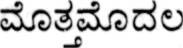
ಮೊತ್ತಮೊದಲ
